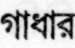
গাধার
